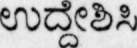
ಉದ್ದೇಶಿಸಿ
